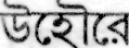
উহৌরে
